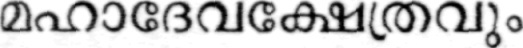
മഹാദേവക്ഷേത്രവും
